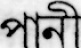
পানী
